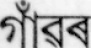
গাঁৱৰ
